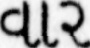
વાર
